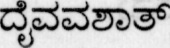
ದೈವವಶಾತ್
